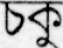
চকু
